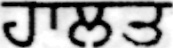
ਹਾਲਤ
